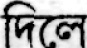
দিলে
